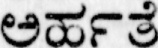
ಅರ್ಹತೆ
